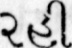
રહી
